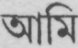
আমি
